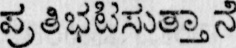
ಪ್ರತಿಭಟಿಸುತ್ತಾನೆ
